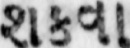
શકવા
